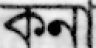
কনা
